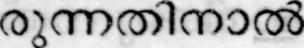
രുന്നതിനാല്‍
